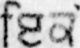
ਇਕ
